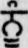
ਨੂੰ
